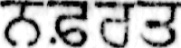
ਨਫ਼ਰਤ
